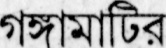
গঙ্গামাটির
